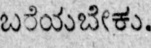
ಬರೆಯಬೇಕು.
